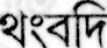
থংবদি
